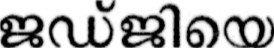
ജഡ്ജിയെ
